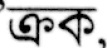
’ক্রক,
